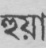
হুয়া
